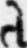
તે
